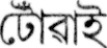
টোঁৱাই
